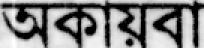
অকায়বা
